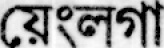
য়েংলগা
